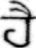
ਹੈ
